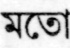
মতো
